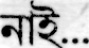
নাই...
